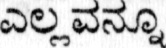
ಎಲ್ಲವನ್ನೂ
